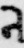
કંઈ
